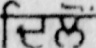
ਦਿਲੋਂ
